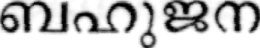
ബഹുജന
